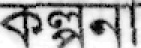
কল্পনা
